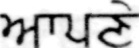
ਆਪਣੇ
